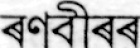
ৰণবীৰৰ
